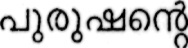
പുരുഷന്റെ
